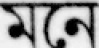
মনে
